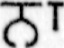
ਨਾ
